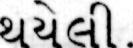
થયેલી.
